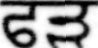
ਫੜ
